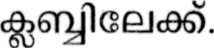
ക്ലബ്ബിലേക്ക്.
